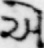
એ
